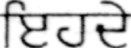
ਇਹਦੇ
